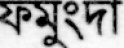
ফমুংদা
